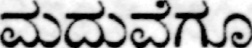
ಮದುವೆಗೂ
